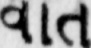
વાત
